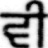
ਵੀ
